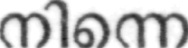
നിന്നെ
